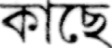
কাছে
